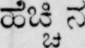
ಹೆಚ್ಚಿನ
